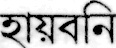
হায়বনি
